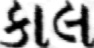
કાલ
